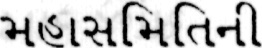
મહાસમિતિની
